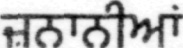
ਜ਼ਨਾਨੀਆਂ
